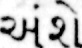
અંશે
